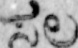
ಸಲ
